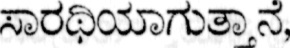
ಸಾರಥಿಯಾಗುತ್ತಾನೆ,
